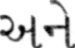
અને
